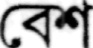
বেশ
